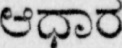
ಆಧಾರ
